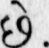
છે.
